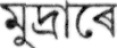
মুদ্রাৰে
